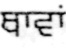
ਥਾਵਾਂ
